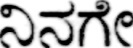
ನಿನಗೇ
